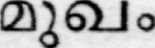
മുഖം
